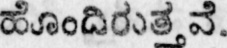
ಹೊಂದಿರುತ್ತವೆ.
